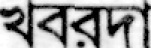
খবরদা
